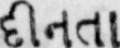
દીનતા
